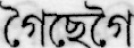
গৈছেগৈ
